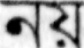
নয়
